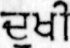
ਦੁਖੀ
